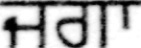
ਜਗਾ
